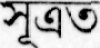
সূত্রত
